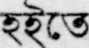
হইতে
